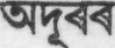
অদূৰৰ
